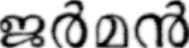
ജര്‍മന്‍
